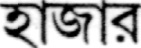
হাজার
